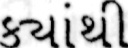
ક્યાંથી
